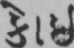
કોઈ
